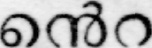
ന്റെ
